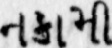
નકામી
